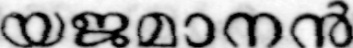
യജമാനന്‍
